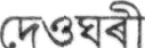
দেওঘৰী
